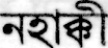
নহাক্কী
